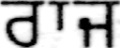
ਰਾਜ
